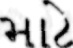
માટે
